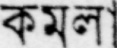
কমলা
